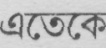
এতেকে
